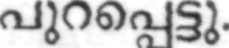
പുറപ്പെട്ടു.
